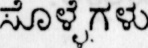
ಸೊಳ್ಳೆಗಳು
